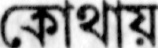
কোথায়
